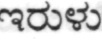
ಇರುಳು
